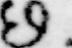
છ.
